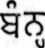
ਬੰਨ੍ਹ
